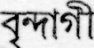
বৃন্দাগী
